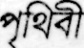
পৃথিবী
